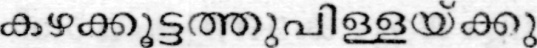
കഴക്കൂട്ടത്തുപിള്ളയ്ക്കു
